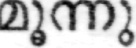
മൂന്നു
